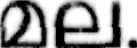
മല.
